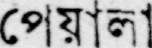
পেয়ালা
